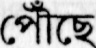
পৌঁছে
